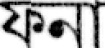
ফনা
